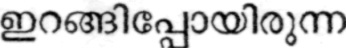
ഇറങ്ങിപ്പോയിരുന്ന
